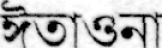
ঈতাওনা
